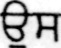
ਉਸ
